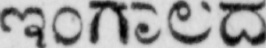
ಇಂಗಾಲದ
